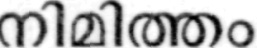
നിമിത്തം
